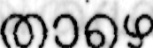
താഴെ
